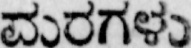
ಮರಗಳು
